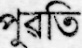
পুৱতি
